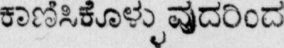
ಕಾಣಿಸಿಕೊಳ್ಳುವುದರಿಂದ
